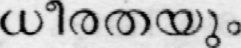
ധീരതയും
